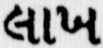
લાખ
